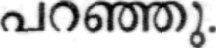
പറഞ്ഞു.
